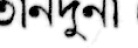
তানদুনা
